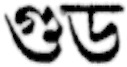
গুড
